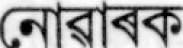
নোৱাৰক
